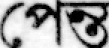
পেন্ত
